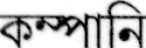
কম্পানি
